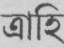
ত্ৰাহি
